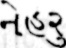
નેહરુ
